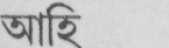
আহি
